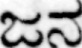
ಜನ
